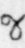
જ
